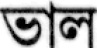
ভাল
